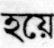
হয়ে
